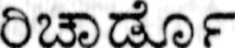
ರಿಚಾರ್ಡೊ
